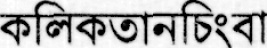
কলিকতানচিংবা
